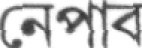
নেপাব
